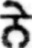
ਨੇ
